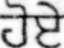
ਹੋਏ
